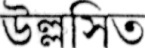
উল্লসিত
